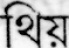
থিয়
